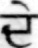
ਦੇ
